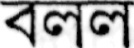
বলল
